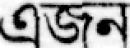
এজন
